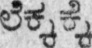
ಲೆಕ್ಕಕ್ಕೆ
